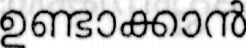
ഉണ്ടാക്കാന്‍
